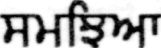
ਸਮਝਿਆ
